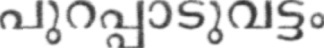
പുറപ്പാടുവട്ടം
